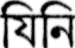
যিনি
